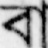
বা
